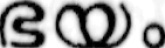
ഭയം
